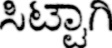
ಸಿಟ್ಟಾಗಿ
